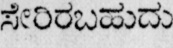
ಸೇರಿರಬಹುದು
